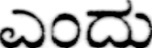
ಎಂದು
